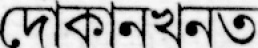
দোকানখনত
